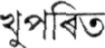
খুপৰিত
